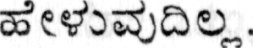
ಹೇಳುವುದಿಲ್ಲ.
